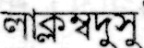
লাক্লম্বদুসু
